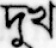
দুখ
